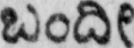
ಬಂದೀ
